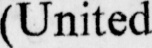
(United
